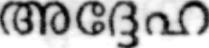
അദ്ദേഹ
